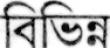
বিভিন্ন
